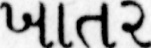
ખાતર
